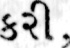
કરી,
